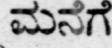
ಮನೆಗೆ
